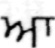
ਆ
